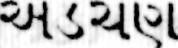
અડચણ
